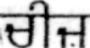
ਚੀਜ਼
